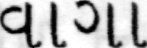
વાગા
